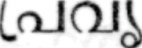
പ്രവൃ
